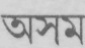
অসম
